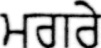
ਮਗਰੇ
